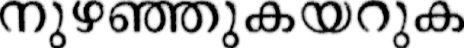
നുഴഞ്ഞുകയറുക
